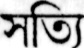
সত্যি
